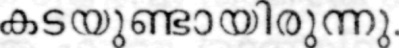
കടയുണ്ടായിരുന്നു.
